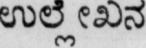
ಉಲ್ಲೇಖನ
